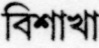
বিশাখা
